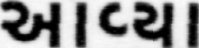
આવ્યા
